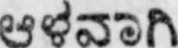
ಆಳವಾಗಿ
